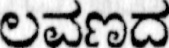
ಲವಣದ
